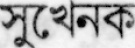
সুখেনক
